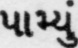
પામ્યું
